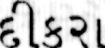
દીકરા
